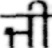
ਜੀ
